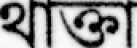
থাক্তা
